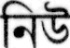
নিউ
